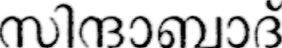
സിന്ദാബാദ്
